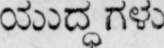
ಯುದ್ಧಗಳು
